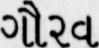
ગૌરવ
